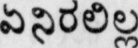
ಏನಿರಲಿಲ್ಲ
